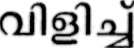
വിളിച്ച്
